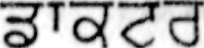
ਡਾਕਟਰ
